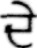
ਦੇ
